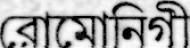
রোমোনিগী
